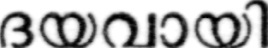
ദയവായി
